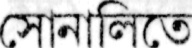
সোনালিতে
